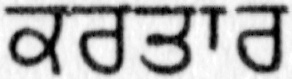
ਕਰਤਾਰ
